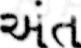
અંત
